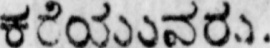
ಕರೆಯುವರು.
